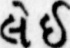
લેઈ
